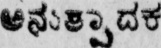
ಅನುತ್ಪಾದಕ
